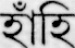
হাঁহি
